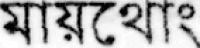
মায়থোং
